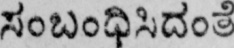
ಸಂಬಂಧಿಸಿದಂತೆ
